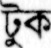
টুক
